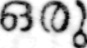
ഒരു
